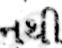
નથી
